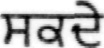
ਸਕਦੇ
